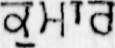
ਕੁਮਾਰ
